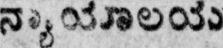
ನ್ಯಾಯಾಲಯ
